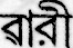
ৱারী
